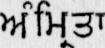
ਅੰਮ੍ਰਿਤਾ
